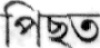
পিছত
